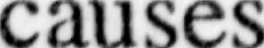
Causes
